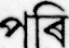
পৰি
